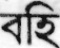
বহি
